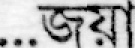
...জয়া
